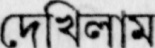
দেখিলাম
